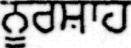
ਨੂਰਸ਼ਾਹ
